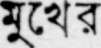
মুখের
